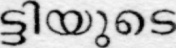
ട്ടിയുടെ
